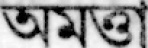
অমত্তা
